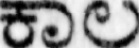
ಕಾಲ
